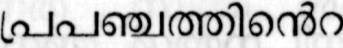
പ്രപഞ്ചത്തിന്റെ
